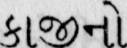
કાજીનો
